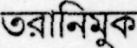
তরানিমুক
